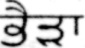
ਭੈੜਾ
